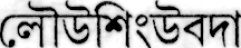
লৌউশিংউবদা
